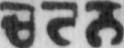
ਚਰਨ
